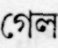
গেল
